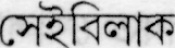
সেইবিলাক
